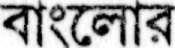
বাংলোর
